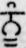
ਨੂੰ
